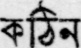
কঠিন
